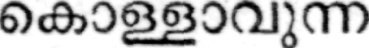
കൊള്ളാവുന്ന
